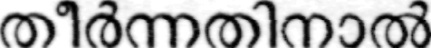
തീര്‍ന്നതിനാല്‍
